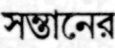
সন্তানের
